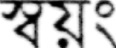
স্বয়ং
